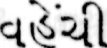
વહેંચી
